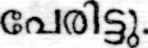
പേരിട്ടു.
